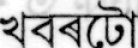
খবৰটো
